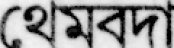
থেমবদা
